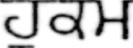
ਹੁਕਮ
